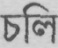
চলি
